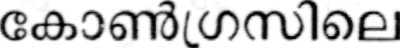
കോണ്‍ഗ്രസിലെ
